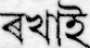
ৰখাই
